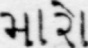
મારો
